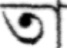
তা
